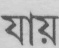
যায়
